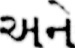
અને
